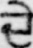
ਦੇ
